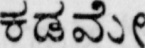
ಕಡಮೇ
